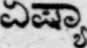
ಏಷ್ಯಾ
